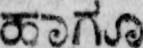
ಹಾಗೂ
